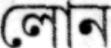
লোন
